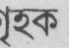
গৃহক
